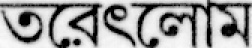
তরেৎলোম
